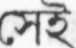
সেই
